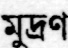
মুদ্রণ
